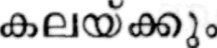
കലയ്ക്കും
